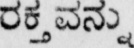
ರಕ್ತವನ್ನು
